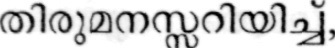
തിരുമനസ്സറിയിച്ച്,
